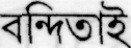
বন্দিতাই
